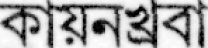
কায়নখ্রবা
